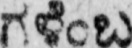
ಗಳೆಂಬ
